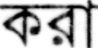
করা
